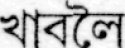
খাবলৈ
